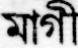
মাগী
